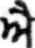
ਐ
